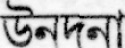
উনদনা
